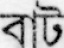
বাট
